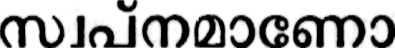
സ്വപ്നമാണോ
